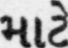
માટે
